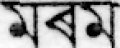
মৰম
